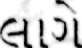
લાગે
